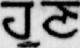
ਹੁਣ
